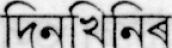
দিনখিনিৰ
